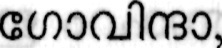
ഗോവിന്ദാ,
